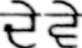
ਦੇਵੇ
